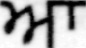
ਆ
